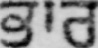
ਭਾਰ
